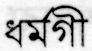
ধর্মগী
